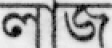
লাজ
